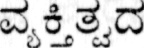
ವ್ಯಕ್ತಿತ್ವದ
